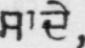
ਸਾਦੇ,
